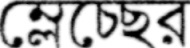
ম্লেচ্ছের
